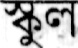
স্কুল
